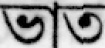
ভাত
